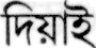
দিয়াই
